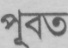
পূবত
